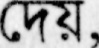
দেয়,
